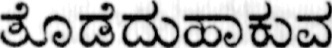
ತೊಡೆದುಹಾಕುವ
